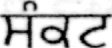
ਸੰਕਟ
